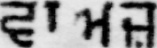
ਵਾਅਜ਼
